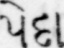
પેદા
